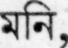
মনি,
